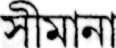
সীমানা
